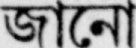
জানো
